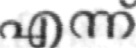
എന്ന്
